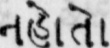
નહોતો
